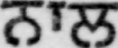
ਨਾਲ
